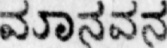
ಮಾನವನ
